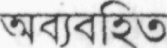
অব্যবহিত
